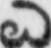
ಎ
